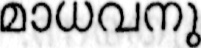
മാധവനു
